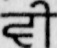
ਵੀ
